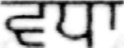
ਵਧਾ
